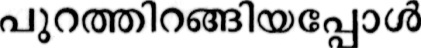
പുറത്തിറങ്ങിയപ്പോള്‍
